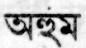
অহুম
